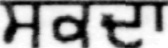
ਸਕਦਾ
